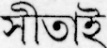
সীতাই
